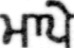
ਮਾਪੇ
